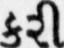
કરી
